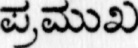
ಪ್ರಮುಖ
